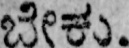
ಬೇಕು.
